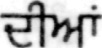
ਦੀਆਂ
